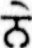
ਨੇ
